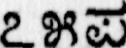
೭೫ಪ
